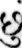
છું
